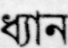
ধ্যান
